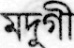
মদুগী
